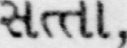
સત્તા,
